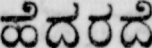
ಹೆದರದೆ
